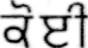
ਕੋਈ
